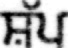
ਸ਼ੱਪ
